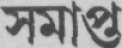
সমাপ্ত
